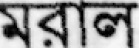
মরাল
